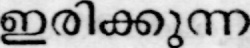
ഇരിക്കുന്ന
